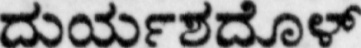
ದುರ್ಯಶದೊಳ್
